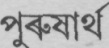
পুৰুষাৰ্থ
